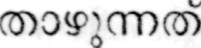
താഴുന്നത്
